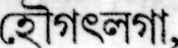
হৌগৎলগা,
